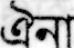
ঐনা
